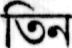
তিন
